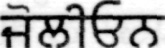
ਜੋਲੀਓਨ
